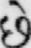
છે
